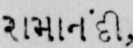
રામાનંદી,
